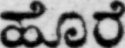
ಹೊರೆ
